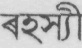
ৰহস্যী
